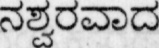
ನಶ್ವರವಾದ
